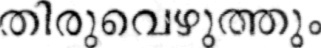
തിരുവെഴുത്തും
